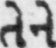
તેને
